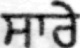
ਸਾਰੇ
